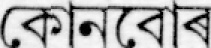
কোনবোৰ
